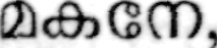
മകനേ,
